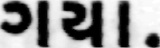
ગયા.
